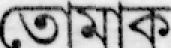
তোমাক
